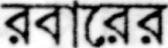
রবারের
